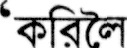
‘করিলৈ
